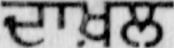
ਦਾਖ਼ਲ
